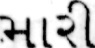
મારી
